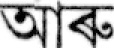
আৰু
